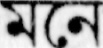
মনে
